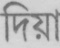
দিয়া
